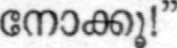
നോക്കൂ!"
